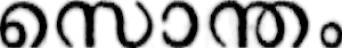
സൊന്തം
